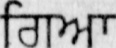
ਗਿਆ
